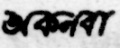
অকনবা
